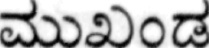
ಮುಖಂಡ
